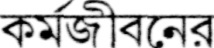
কর্মজীবনের
